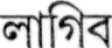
লাগিব
